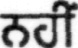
ਨਹੀਂ
